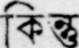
কিন্তু
